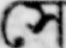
সে
